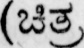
(ಚಿತ್ರ
